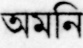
অমনি
